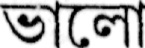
ভালো
